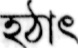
হঠাৎ
